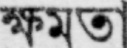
ক্ষমতা
